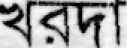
খরদা
